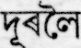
দূৰলৈ
